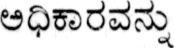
ಅಧಿಕಾರವನ್ನು
